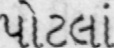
પોટલાં
